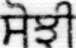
ਸੋਝੀ
